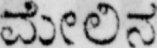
ಮೇಲಿನ
